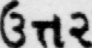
ઉત્તર
